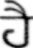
ਹੈ
